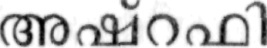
അഷ്റഫി
